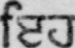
ਇਹ
